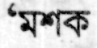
‘মশক
